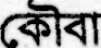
কৌবা
